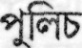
পুলিচ
